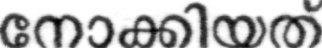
നോക്കിയത്
